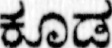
ಕೂಡ
